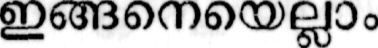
ഇങ്ങനെയെല്ലാം
